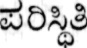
ಪರಿಸ್ಥಿತಿ
